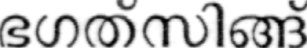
ഭഗത്‌സിങ്ങ്
